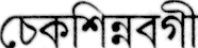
চেকশিন্নবগী
